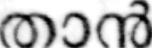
താന്‍
